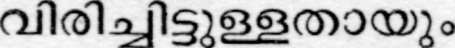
വിരിച്ചിട്ടുള്ളതായും
